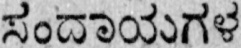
ಸಂದಾಯಗಳ
